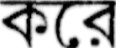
করে
